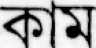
কাম
